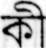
কী
